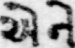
એને
